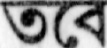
তবে
